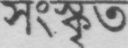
সংস্কৃত
